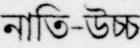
নাতি-উচ্চ
